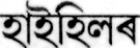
হাইহিলৰ
